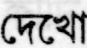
দেখো
